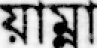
য়াম্না
